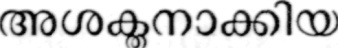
അശക്തനാക്കിയ
